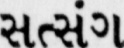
સત્સંગ
